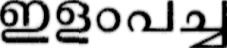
ഇളംപച്ച
